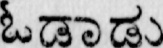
ಓಡಾಡು
